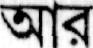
আর
